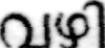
വഴി
